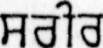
ਸਰੀਰ
